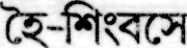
হৈ-শিংবসে
